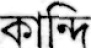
কান্দি
